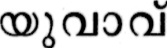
യുവാവ്
